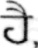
ਹੈ,
